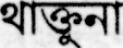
থাক্তুনা
